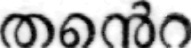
തന്റെ
